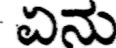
ಏನು
